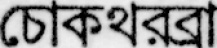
চোকথরব্রা
